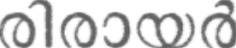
രിരായര്‍
